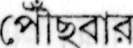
পৌঁছবার
